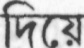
দিয়ে
